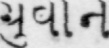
યુવાન
